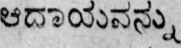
ಆದಾಯವನ್ನು
